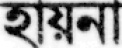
হায়না
